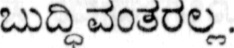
ಬುದ್ಧಿವಂತರಲ್ಲ.
